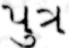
પુત્ર
